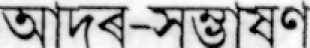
আদৰ-সম্ভাষণ
